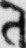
તે
